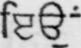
ਇਉਂ
